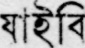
যাইবি
